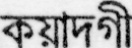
কয়াদগী
